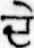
ਦੇ
